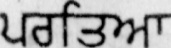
ਪਰਤਿਆ
